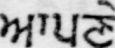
ਆਪਣੇ
